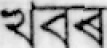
খবৰ
